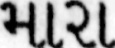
મારા
